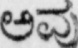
ಅವು
